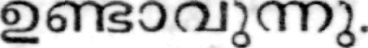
ഉണ്ടാവുന്നു.
